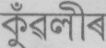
কুঁৱলীৰ
